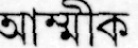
আম্মীক
